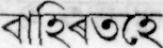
বাহিৰতহে
